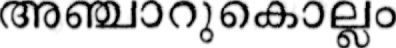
അഞ്ചാറുകൊല്ലം
